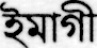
ইমাগী
